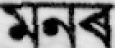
মনৰ
